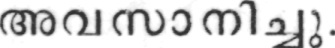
അവസാനിച്ചു.
